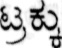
ಟ್ರಕ್ಕು
